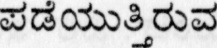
ಪಡೆಯುತ್ತಿರುವ
